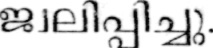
ജ്വലിപ്പിച്ചു.
